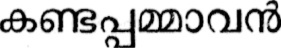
കണ്ടപ്പമ്മാവന്‍
